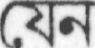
যেন
